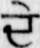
ਦੇ
